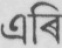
এৰি
